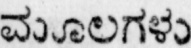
ಮೂಲಗಳು
